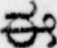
ಈ
